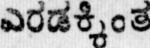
ಎರಡಕ್ಕಿಂತ
